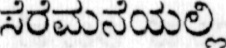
ಸೆರೆಮನೆಯಲ್ಲಿ
